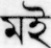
মই
